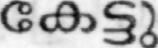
കേട്ടു
